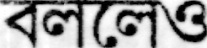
বললেও
